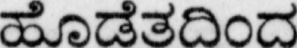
ಹೊಡೆತದಿಂದ
